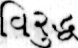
વિરુદ્ધ
